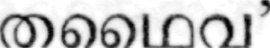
തഥൈവ'
